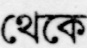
থেকে
